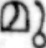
മു
